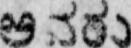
ಅವರು
